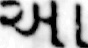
આ
